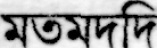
মতমদদি
